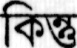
কিন্তু
